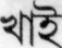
খাই
